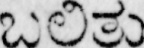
ಬಲಿತು
